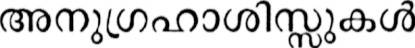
അനുഗ്രഹാശിസ്സുകള്‍
